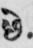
છે.
